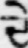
ਦੇ
